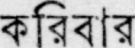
করিবার
